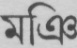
মঞি
